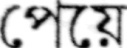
পেয়ে
